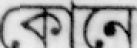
কোনে
